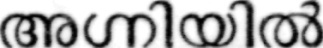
അഗ്നിയില്‍
